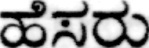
ಹೆಸರು
